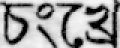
চংখ্রে
